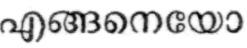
എങ്ങനെയോ
